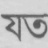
যত
